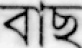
বাছ
